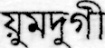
য়ুমদুগী
